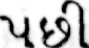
પછી
